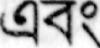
এবং
